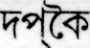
দপ‌কৈ
